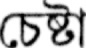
চেষ্টা
